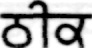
ਠੀਕ
